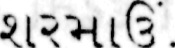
શરમાઉં.
